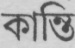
কান্তি
